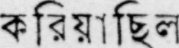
করিয়াছিল
